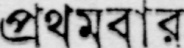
প্রথমবার
